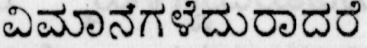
ವಿಮಾನಗಳೆದುರಾದರೆ
